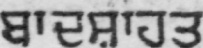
ਬਾਦਸ਼ਾਹਤ
